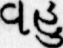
વહુ
